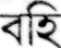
বহি
